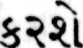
કરશે
